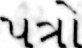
પત્રો
